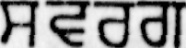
ਸਵਰਗ
